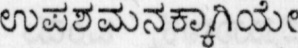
ಉಪಶಮನಕ್ಕಾಗಿಯೇ
